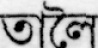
তালৈ
